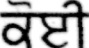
ਕੋਈ
